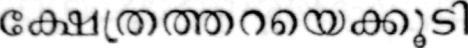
ക്ഷേത്രത്തറയെക്കൂടി
